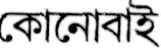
কোনোবাই
